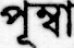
পূম্বা
